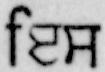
ਇਸ
